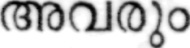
അവരും
